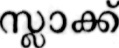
സ്ളാക്ക്
